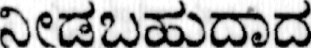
ನೀಡಬಹುದಾದ
